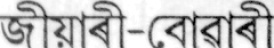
জীয়াৰী-বোৱাৰী
